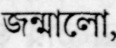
জন্মালো,
